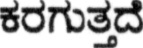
ಕರಗುತ್ತದೆ
